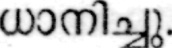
ധാനിച്ചു.
